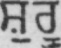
ਸ਼ੁਰੂ
